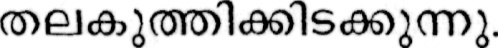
തലകുത്തിക്കിടക്കുന്നു.
